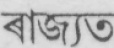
ৰাজ্যত
